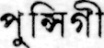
পুন্সিগী
